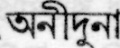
অনীদুনা
